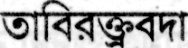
তাবিরক্ত্রবদা
